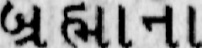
બ્રહ્માના
